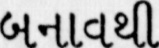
બનાવથી
